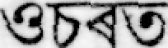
ওচৰত
